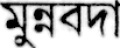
মুন্নবদা
